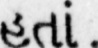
હતાં.
